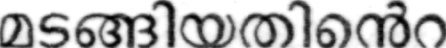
മടങ്ങിയതിന്റെ
